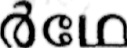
ര്‍ഥേ
